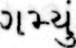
ગમ્યું
